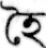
হৈ
